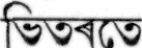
ভিতৰতে
